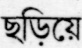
ছড়িয়ে
